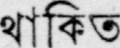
থাকিত
